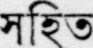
সহিত
